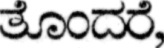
ತೊಂದರೆ,
